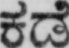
ಕಡೆ
